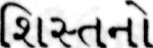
શિસ્તનો
